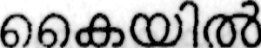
കൈയില്‍
